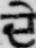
ਦੇ
